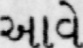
આવે
